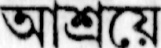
আশ্রয়ে
